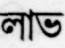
লাভ
